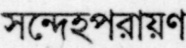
সন্দেহপরায়ণ
